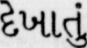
દેખાતું
